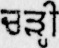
ਚੜ੍ਹੀ
